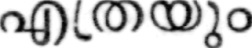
എത്രയും
